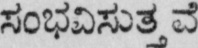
ಸಂಭವಿಸುತ್ತವೆ
